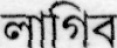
লাগিব
